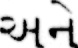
અને
